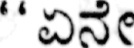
"ಏನೇ
